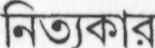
নিত্যকার
